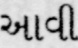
આવી
